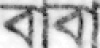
বাবা
